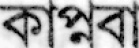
কাপ্নবা
